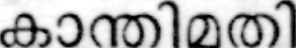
കാന്തിമതി
